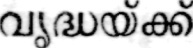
വൃദ്ധയ്ക്ക്
